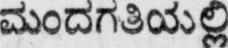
ಮಂದಗತಿಯಲ್ಲಿ
